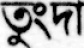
তংদা
